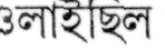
ওলাইছিল
